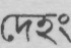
দেহং
